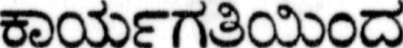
ಕಾರ್ಯಗತಿಯಿಂದ
